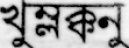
খুম্লক্কনু
